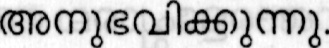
അനുഭവിക്കുന്നു.
